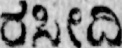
ರಸೀದಿ
